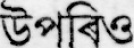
উপৰিও
